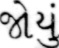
જોયું
